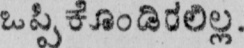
ಒಪ್ಪಿಕೊಂಡಿರಲಿಲ್ಲ.
